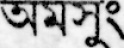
অমসুং
